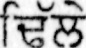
ਢਿੱਲੇ
